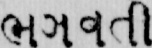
ભગવતી
